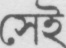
সেই
